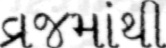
વ્રજમાંથી
